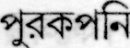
পুরকপনি
